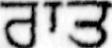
ਰਾਤ
